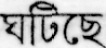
ঘটিছে
